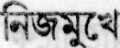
নিজমুখে
